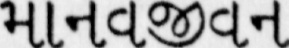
માનવજીવન
